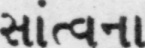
સાંત્વના
